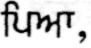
ਪਿਆ,
